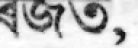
ৰজত,
